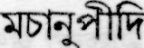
মচানুপীদি
